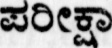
ಪರೀಕ್ಷಾ
